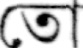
তো
